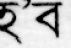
হ'ব
